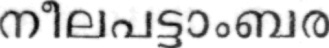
നീലപട്ടാംബര
